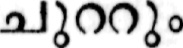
ചുററും
